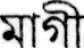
মাগী
